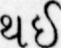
થઈ
